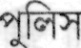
পুলিস
